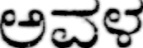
ಅವಳ
